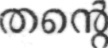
തന്റെ
